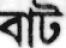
বাট
